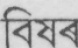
বিষৰ
